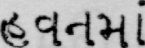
હવનમાં
